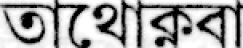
তাথোক্নবা
